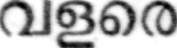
വളരെ
